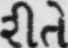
રીતે
